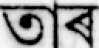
তাৰ
